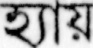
হ্যায়
